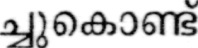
ച്ചുകൊണ്ട്
